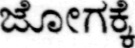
ಜೋಗಕ್ಕೆ
